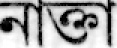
নাক্তা
